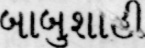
બાબુશાહી
